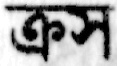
ক্রস
